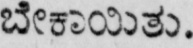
ಬೇಕಾಯಿತು.
